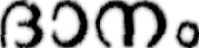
ദാനം
